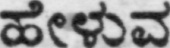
ಹೇಳುವ
